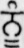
ਨੂੰ
